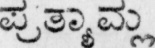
ಪ್ರತ್ಯಾಮ್ಲ
